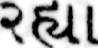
રહ્યા
